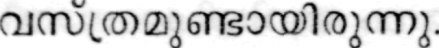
വസ്ത്രമുണ്ടായിരുന്നു.
